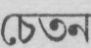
চেতন
